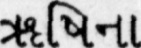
ૠષિના
